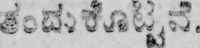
ತಂದುಕೊಟ್ಟಿವೆ.
